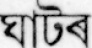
ঘাটৰ
